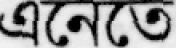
এনেতে
